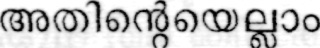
അതിന്റെയെല്ലാം
